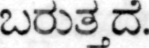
ಬರುತ್ತದೆ.
